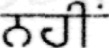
ਨਹੀਂ
